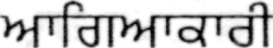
ਆਗਿਆਕਾਰੀ
